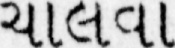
ચાલવા
